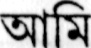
আমি
